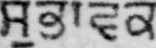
ਸੁਭਾਵਕ
